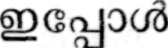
ഇപ്പോള്‍
